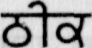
ਠੀਕ
